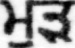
ਮੁੜ
